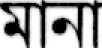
মানা
